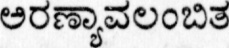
ಅರಣ್ಯಾವಲಂಬಿತ
